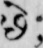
છે;
